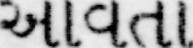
આવતા
